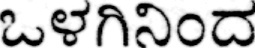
ಒಳಗಿನಿಂದ
